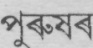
পুৰুষৰ
